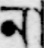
না
